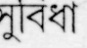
সুবিধা
